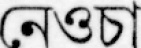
নেওচা
